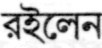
রইলেন
